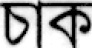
চাক
